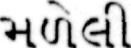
મળેલી
